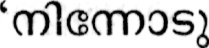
'നിന്നോടു
